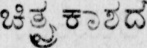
ಚಿತ್ಪ್ರಕಾಶದ
